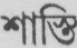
শাস্তি
